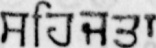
ਸਹਿਜਤਾ
